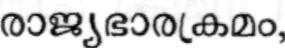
രാജ്യഭാരക്രമം,
